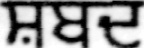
ਸ਼ਬਦ
